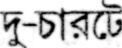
দু-চারটে
